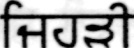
ਜਿਹੜੀ
